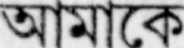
আমাকে
